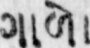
ગાળો
